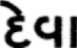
દેવા
